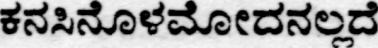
ಕನಸಿನೊಳಮೋದನಲ್ಲದೆ
